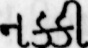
નક્કી
